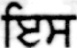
ਇਸ
